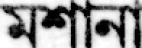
মশানা
